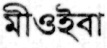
মীওইবা
